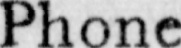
Phone
